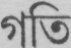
গতি
